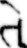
તે
